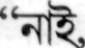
"নাই,
